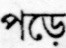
পড়ে
